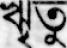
ঋৃতু
